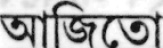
আজিতো
